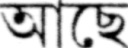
আছে
